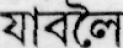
যাবলৈ
